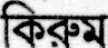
কিরুম
